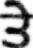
ਤੇ
